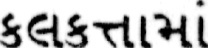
કલકત્તામાં
